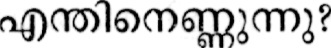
എന്തിനെണ്ണുന്നു?
